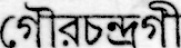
গৌরচন্দ্রগী
